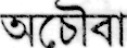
অচৌবা
